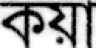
কয়া
